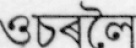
ওচৰলৈ
